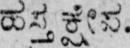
ಹಸ್ತಕ್ಷೇಪ.
